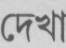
দেখা
